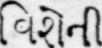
વિશેની
